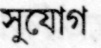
সুযোগ
